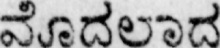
ಮೊದಲಾದ
